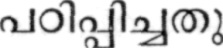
പഠിപ്പിച്ചതു
